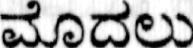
ಮೊದಲು
